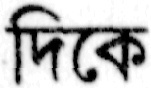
দিকে
